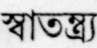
স্বাতন্ত্র্য
